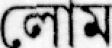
লোম
